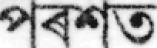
পৰশত
